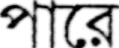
পারে
